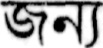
জন্য
